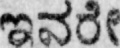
ಇವರೇ
